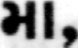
મા,
